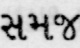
સમજ
